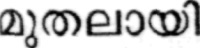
മുതലായി
